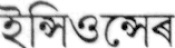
ইন্সিওন্সেৰ
